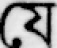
যে
